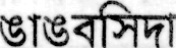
ঙাঙবসিদা
